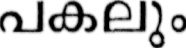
പകലും
